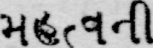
મહત્વની
